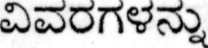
ವಿವರಗಳನ್ನು
